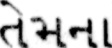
તેમના
